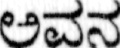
ಅವನ
